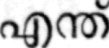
എന്ത്
